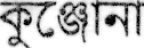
কুঞ্জোনা
